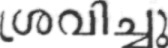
ശ്രവിച്ചു
